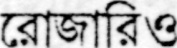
রোজারিও
